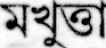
মখুত্তা
